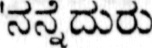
‘ನನ್ನೆದುರು
